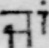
ਜਾਂ
